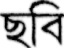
ছবি
